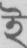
ই
